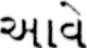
આવે
